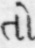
તો
